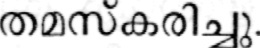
തമസ്കരിച്ചു.
